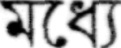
মধ্যে
